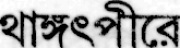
থাঙ্গৎপীরে
